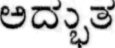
ಅದ್ಭುತ
